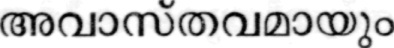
അവാസ്തവമായും
